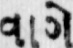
વાગે
